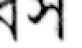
বস
